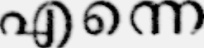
എന്നെ
